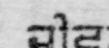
ਜੀਵਾ
